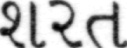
શરત
